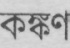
কঙ্কণ
